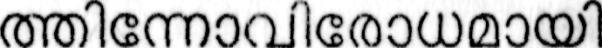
ത്തിന്നോവിരോധമായി
